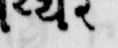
પથ્થર
